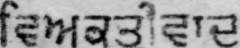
ਵਿਅਕਤੀਵਾਦ
